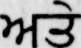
ਅਤੇ
